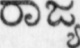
ರಾಜ್ಯ
